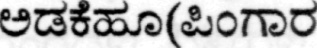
ಅಡಕೆಹೂ(ಪಿಂಗಾರ
